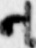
ન
